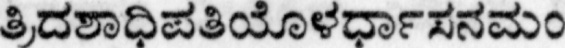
ತ್ರಿದಶಾಧಿಪತಿಯೊಳರ್ಧಾಸನಮಂ
